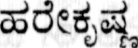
ಹರೇಕೃಷ್ಣ
